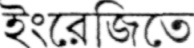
ইংরেজিতে
